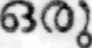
ഒരു
